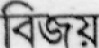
বিজয়
